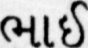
ભાઈ
